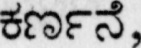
ಕರ್ಣನೆ,
